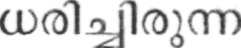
ധരിച്ചിരുന്ന
